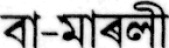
বা-মাৰলী
